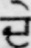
ਦੇ
